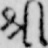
શ્રી
